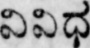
ವಿವಿಧ
